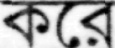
করে
